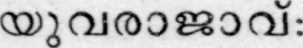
യുവരാജാവ്:
